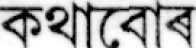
কথাবোৰ
